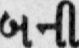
બની
